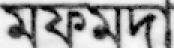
মফমদা
